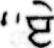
''ਏ
